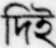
দিই
